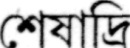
শেষাদ্রি
